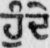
ਹੁੰਦੇ
